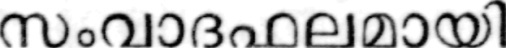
സംവാദഫലമായി
